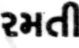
રમતી
